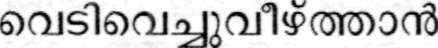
വെടിവെച്ചുവീഴ്ത്താന്‍
